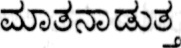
ಮಾತನಾಡುತ್ತ
